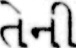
તેની
